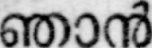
ഞാന്‍
